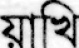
য়াখি
